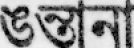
ঙন্তানা
